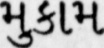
મુકામ
